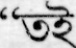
"তই
